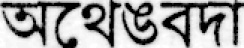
অথেঙবদা
